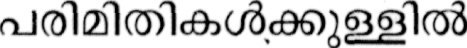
പരിമിതികള്‍ക്കുള്ളില്‍
